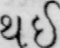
થઈ
